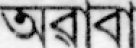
অৱাবা
